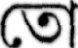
তো
